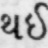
થઈ
